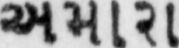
અમારા
